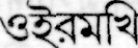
ওইরমখি
